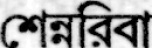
শেন্নরিবা
